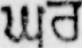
ਘਰ
